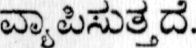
ವ್ಯಾಪಿಸುತ್ತದೆ.
